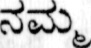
ನಮ್ಮ
